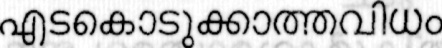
എടകൊടുക്കാത്തവിധം
